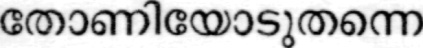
തോണിയോടുതന്നെ
